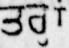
ਤਰ੍ਹਾਂ
